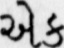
એક
